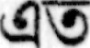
এত
